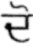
ਦੋ
